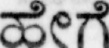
ಹೇಗೆ
